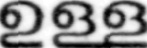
ഉള്ള
